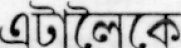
এটালৈকে
